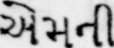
એમની
